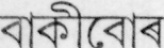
বাকীবোৰ
